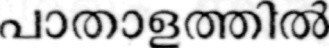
പാതാളത്തില്‍
